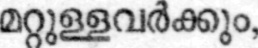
മറ്റുള്ളവര്‍ക്കും,
